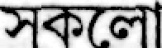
সকলো
